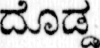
ದೊಡ್ಡ
